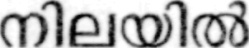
നിലയില്‍
